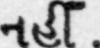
નહીં.
